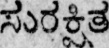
ಸುರಕ್ಷಿತ
